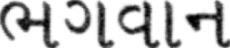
ભગવાન
